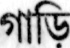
গাড়ি
